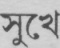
সুখে
